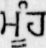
ਮੂੰਹ
